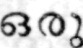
ഒരു
